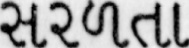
સરળતા
